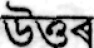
উত্তৰ
